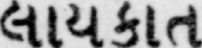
લાયકાત
